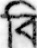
বি
